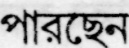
পারছেন
